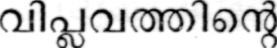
വിപ്ലവത്തിന്റെ
